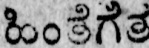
ಹಿಂತೆಗೆತ
